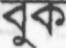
বুক
